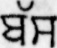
ਬੱਸ
